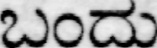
ಬಂದು
